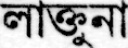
লাক্তুনা
